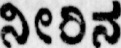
ನೀರಿನ
